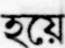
হয়ে
